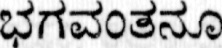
ಭಗವಂತನೂ
